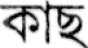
কাছ
